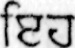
ਇਹ
